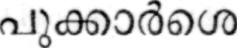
പുക്കാര്‍ശെ
